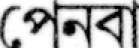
পেনবা
